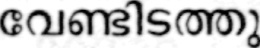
വേണ്ടിടത്തു
